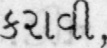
કરાવી,
